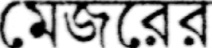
মেজরের
